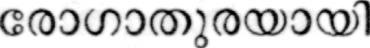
രോഗാതുരയായി
